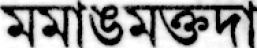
মমাঙমক্তদা
